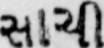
સાચી
